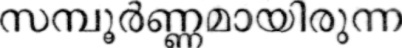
സമ്പൂര്‍ണ്ണമായിരുന്ന
